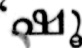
‘ഷൂ
